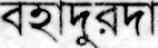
বহাদুরদা
